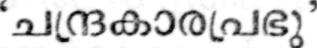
'ചന്ദ്രകാരപ്രഭു'
